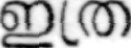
ഇത്ര
